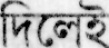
দিলেই
